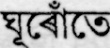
ঘূৰোঁতে
